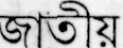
জাতীয়
